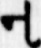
ન
